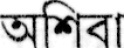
অশিবা
